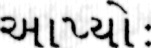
આપ્યો:
